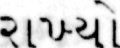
રાખ્ચો
